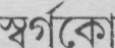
স্বর্গকো
